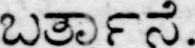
ಬರ್ತಾನೆ.
